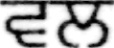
ਵਲ
